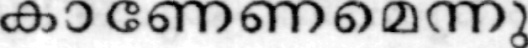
കാണേണമെന്നു
